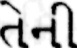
તેની
